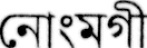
নোংমগী
